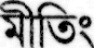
মীতিং
